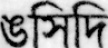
ঙসিদি
